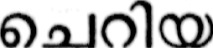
ചെറിയ
